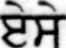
ਏਸੇ
